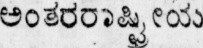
ಅಂತರರಾಷ್ಟ್ರೀಯ
